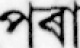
পৰা
